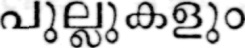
പുല്ലുകളും
